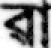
ৱা
